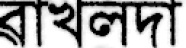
ৱাখলদা
